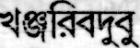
খঞ্জরিবদুবু
